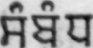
ਸੰਬੰਧ
